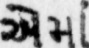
એમાં
